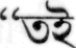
"তই
